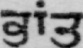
ਭਾਂਤ
